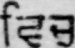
ਵਿਚ
